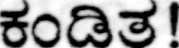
ಕಂಡಿತ!
